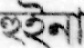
হুইনা
